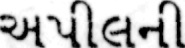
અપીલની
